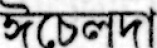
ঈচেলদা
